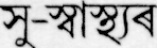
সু-স্বাস্হ্যৰ
